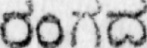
ರಂಗದ
